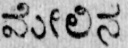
ಮೇಲಿನ
